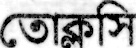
তোক্লসি
